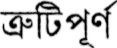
ত্রুটিপূর্ণ
